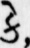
કે,
